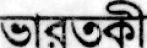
ভারতকী
